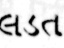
લડત
